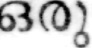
ഒരു
